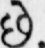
છે.
